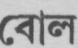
বোল
